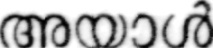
അയാള്‍
